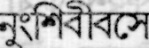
নুংশিবীবসে
